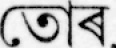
তোৰ
